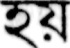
হয়
